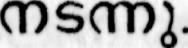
നടന്നു.
